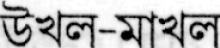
উখল-মাখল
